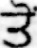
ਤੋਂ
